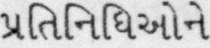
પ્રતિનિધિઓને
